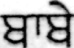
ਬਾਬੇ
